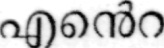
എന്റെ
